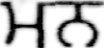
ਮਨ
